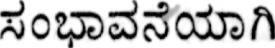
ಸಂಭಾವನೆಯಾಗಿ
